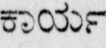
ಕಾರ್ಯ
